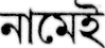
নামেই
